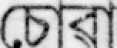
চোৱা
